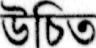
উচিত
